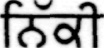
ਨਿੱਕੀ
